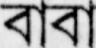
বাবা
